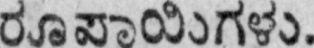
ರೂಪಾಯಿಗಳು.
